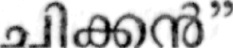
ചിക്കന്‍”
